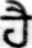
ਹੈ
